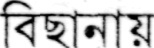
বিছানায়
